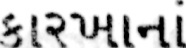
કારખનાં
